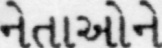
નેતાઓને
